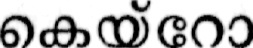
കെയ്റോ
